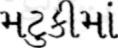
મટુકીમાં
